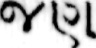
જણ
